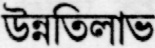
উন্নতিলাভ
